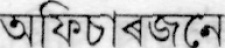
অফিচাৰজনে
